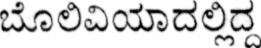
ಬೊಲಿವಿಯಾದಲ್ಲಿದ್ದ
